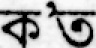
ক'ত
